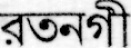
রতনগী
